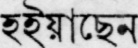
হইয়াছেন
